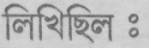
লিখিছিলঃ
